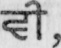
ਵੀ,
